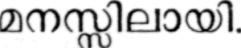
മനസ്സിലായി.
